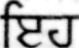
ਇਹ
